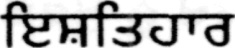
ਇਸ਼ਤਿਹਾਰ
